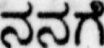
ನನಗೆ
